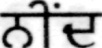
ਨੀਂਦ
